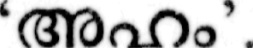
'അഹം'.
